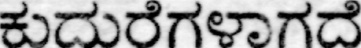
ಕುದುರೆಗಳಾಗದೆ
